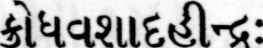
ક્રોધવશાદહીન્દ્રઃ
